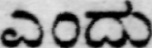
ಎಂದು
